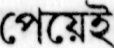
পেয়েই
